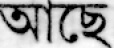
আছে
